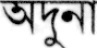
অদুনা
